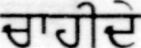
ਚਾਹੀਦੇ
